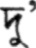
দু’
